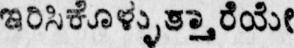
ಇರಿಸಿಕೊಳ್ಳುತ್ತಾರೆಯೇ
